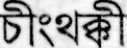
চীংথক্কী
